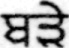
ਬੜੇ
